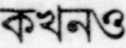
কখনও
